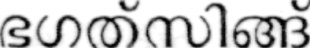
ഭഗത്‌സിങ്ങ്
